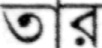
তার
